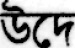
উদে
